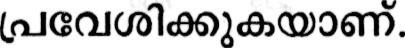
പ്രവേശിക്കുകയാണ്.
